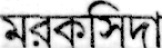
মরমসিদা
